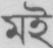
মই
